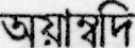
অয়াম্বদি
